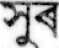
সুৰ
